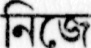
নিজে
